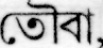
তৌবা,
